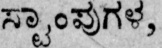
ಸ್ಟಾಂಪುಗಳ
